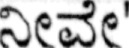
ನೀವೇ’
